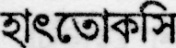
হাৎতোকসি
